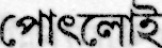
পোৎলোই
